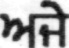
ਅਜੇ
